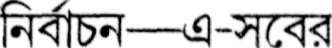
নির্বাচন-এ-সবের
